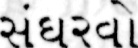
સંઘરવો
